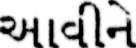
આવીને
